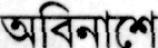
অবিনাশে
